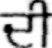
ਦੀ
